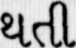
થતી
